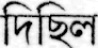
দিছিল
